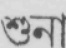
শুনা
